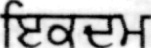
ਇਕਦਮ
